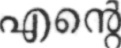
എന്റെ
